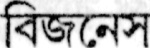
বিজনেস
